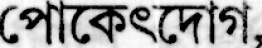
পোকেৎদোগ,
